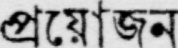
প্রয়োজন
